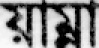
য়াম্না
